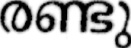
രണ്ടു
